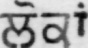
ਲੋਕਾਂ
